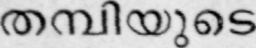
തമ്പിയുടെ
